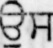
ਉਸ
